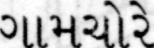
ગામચોરે
